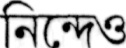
নিন্দেও
